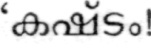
‘കഷ്ടം!
